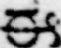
ಈ
